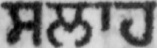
ਸਲਾਹ
